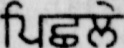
ਪਿਛਲੇ
